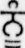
ਨੂੰ
